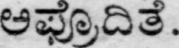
ಅಫ್ರೊದಿತೆ.
